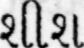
શીશ
